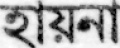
হায়ন
